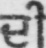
ਦੀ
